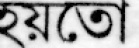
হয়তো
